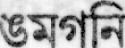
ঙমগনি
